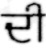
ਦੀ
